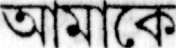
আমাকে
